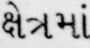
ક્ષેત્રમાં
